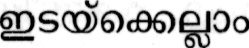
ഇടയ്ക്കെല്ലാം
